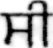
ਸੀ
